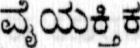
ವೈಯಕ್ತಿಕ
